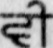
ਵੀ
